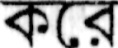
করে
